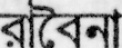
রাবৈনা
